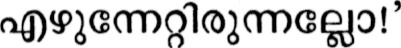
എഴുന്നേറ്റിരുന്നല്ലോ!’
